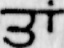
ਤਾਂ
